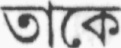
তাকে
